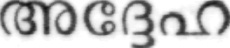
അദ്ദേഹ
